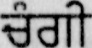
ਚੰਗੀ
